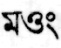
মওং
